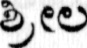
ಶ್ರೀಲ
